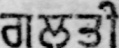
ਗਲਤੀ
